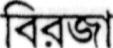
বিরজা
